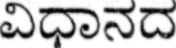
ವಿಧಾನದ
